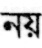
নয়
